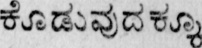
ಕೊಡುವುದಕ್ಕೂ
